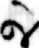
જે
